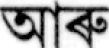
আৰু
